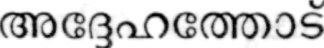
അദ്ദേഹത്തോട്
